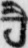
ਹੈ
